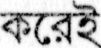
করেই
